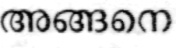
അങ്ങനെ
